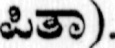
ಪಿತಾ).
